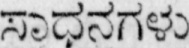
ಸಾಧನಗಳು
